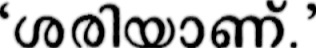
‘ശരിയാണ്.’
